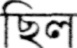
ছিল
